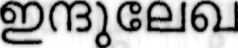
ഇന്ദുലേഖ
